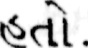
હતો.
